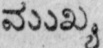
ಮುಖ್ಯ
